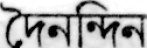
দৈনন্দিন
